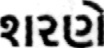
શરણે
